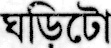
ঘড়িটো
